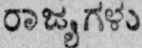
ರಾಜ್ಯಗಳು
